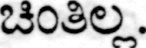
ಚಿಂತಿಲ್ಲ.
